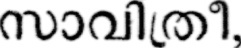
സാവിത്രീ,
